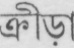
ক্ৰীড়া
